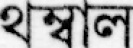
থম্বাল
